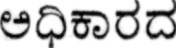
ಅಧಿಕಾರದ
